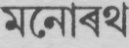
মনোৰথ
